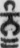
ਨੂੰ
